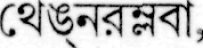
থেঙনরম্লবা
